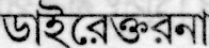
ডাইরেক্তরনা
